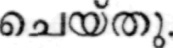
ചെയ്തു.
